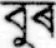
বুৰ
